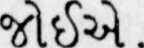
જોઈએ.
